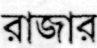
রাজার
